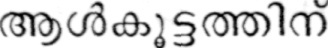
ആള്‍കൂട്ടത്തിന്
